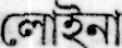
লোইনা
